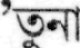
’তুনা
